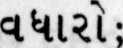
વધારો;
